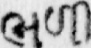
ભળી
